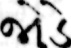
જોડે
